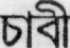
চাবী
